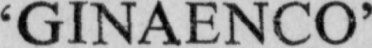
‘GINAENCO’
